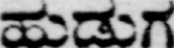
ಹುಡುಗ
